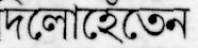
দিলোহেঁতেন
